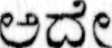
ಅದೇ
